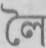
লৈ
